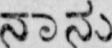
ನಾನು
